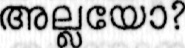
അല്ലയോ?
